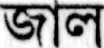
জাল
